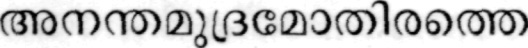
അനന്തമുദ്രമോതിരത്തെ
